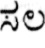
ಸಲ
